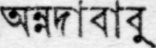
অন্নদাবাবু
